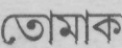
তোমাক
